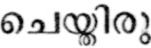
ചെയ്തിരു
